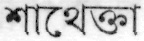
শাথেক্তা
